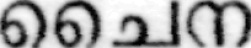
ചൈന
